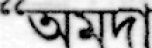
“অমদা
